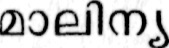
മാലിന്യ
